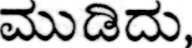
ಮುಡಿದು,
